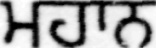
ਮਹਾਨ
